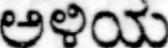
ಅಳಿಯ
